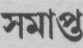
সমাপ্ত
